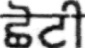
ਛੋਟੀ
